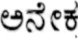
ಅನೇಕ
